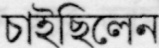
চাইছিলেন
